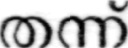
തന്ന്
